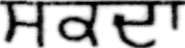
ਸਕਦਾ
